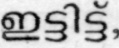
ഇട്ടിട്ട്,
